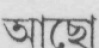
আছো
